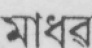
মাধৱ
